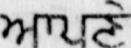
ਆਪਣੇ
